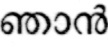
ഞാന്‍
